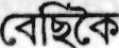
বেছিকৈ
